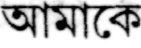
আমাকে
